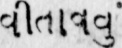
વીતાવવું
